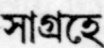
সাগ্রহে
